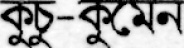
কুচু-কুমেন
